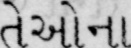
તેઓના
